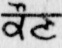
ਕੌਣ
